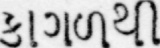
કાગળથી
